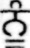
ਨੂੰ
